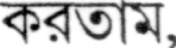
করতাম,
